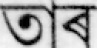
তাৰ
